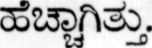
ಹೆಚ್ಚಾಗಿತ್ತು.
